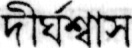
দীর্ঘশ্বাস
